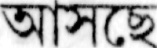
আসছে
